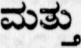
ಮತ್ತು
